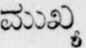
ಮುಖ್ಯ
